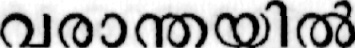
വരാന്തയില്‍
